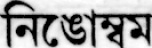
নিঙোম্বম
